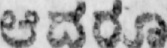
ಆದರೂ
